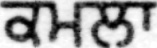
ਕਮਲਾ
